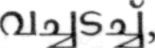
വച്ചടച്ച്,
